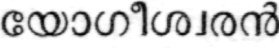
യോഗീശ്വരന്‍
